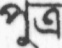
পুত্র
